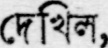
দেখিল,
